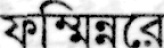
ফম্মিন্নরে
